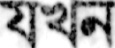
যখন
